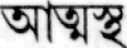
আত্মস্থ
